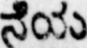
ನೆಯ
